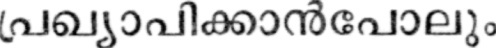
പ്രഖ്യാപിക്കാന്‍പോലും
